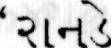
'રાનડે
